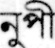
নুপী
